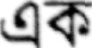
এক
